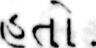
હતો.
